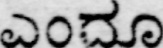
ಎಂದೂ
